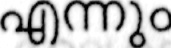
എന്നും
